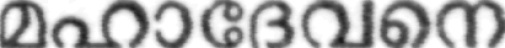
മഹാദേവനെ
